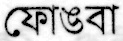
ফোঙবা
